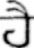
ਹੈ
